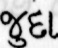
જુદા
